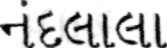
નંદલાલા
